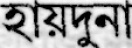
হায়দুনা
